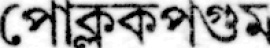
পোক্লকপগুম
